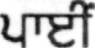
ਪਾਈਂ
